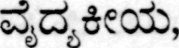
ವೈದ್ಯಕೀಯ,
